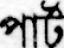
পার্ট
